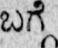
ಬಗ್ಗೆ
